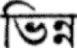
ভিন্ন
